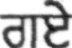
ਗਏ
